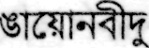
ঙায়োনবীদু
